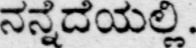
ನನ್ನೆದೆಯಲ್ಲಿ.
